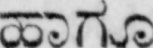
ಹಾಗೂ
